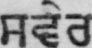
ਸਵੇਰ
